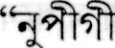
“নুপীগী
